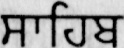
ਸਾਹਿਬ
